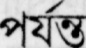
পর্যন্ত
